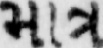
માત્ર
